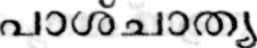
പാശ്ചാത്യ
